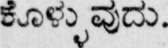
ಕೊಳ್ಳುವುದು.
